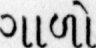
ગાળો
